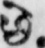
છે.
